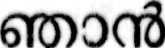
ഞാന്‍
